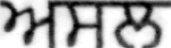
ਅਸਲ
